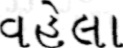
વહેલા
